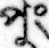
পুং
